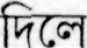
দিলে
